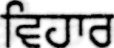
ਵਿਹਾਰ
